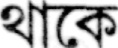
থাকে
